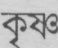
কৃষ্ণ
